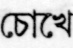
চোখে
